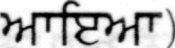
ਆਇਆ)
